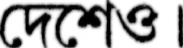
দেশেও।
